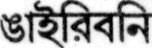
ঙাইরিবনি
